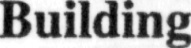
Building
